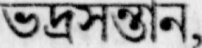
ভদ্রসন্তান,
